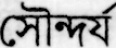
সৌন্দৰ্য
